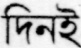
দিনই
